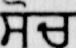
ਸੋਚ
